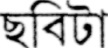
ছবিটা
